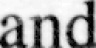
and
